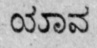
ಯಾವ
